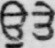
ਉਤੇ
